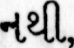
નથી,
